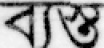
ব্যস্ত
